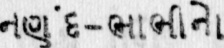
નણંદ-ભાભીનો
